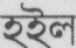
হইল
